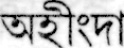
অহীংদা
